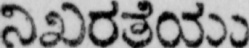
ನಿಖರತೆಯು
